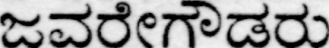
ಜವರೇಗೌಡರು
